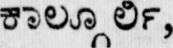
ಕಾಲ್ಗೂರ್ಲಿ,
